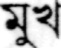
মুখ
